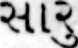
સારુ
